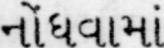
નોંધવામાં
